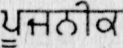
ਪੂਜਨੀਕ
